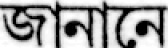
জানানে
